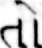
તો
